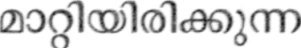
മാറ്റിയിരിക്കുന്ന
